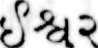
ઈશ્વર
